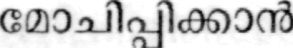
മോചിപ്പിക്കാന്‍
